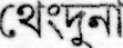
থেংদুনা
